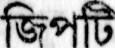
জিপটি
